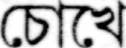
চোখে
